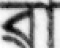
ৱা
